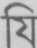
যি
